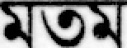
মতম
